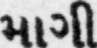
માગી
